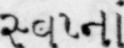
સ્વપ્નાં
